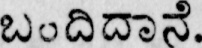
ಬಂದಿದಾನೆ.
